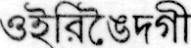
ওইরিঙৈদগী
